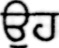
ਉਹ
